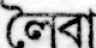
লৈবা
